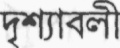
দৃশ্যাবলী
